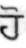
ਹੋ
